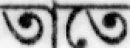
তাতে
